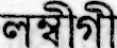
লম্বীগী
